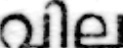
വില
